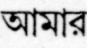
আমার
